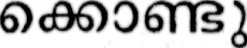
ക്കൊണ്ടു
